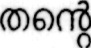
തന്റെ
